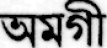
অমগী
